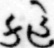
કહે
